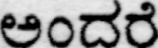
ಅಂದರೆ
